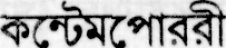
কন্টেমপোররী
